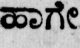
ಹಾಗೇ
